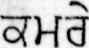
ਕਮਰੇ
